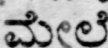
ಮೇಲೆ
